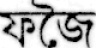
ফজৈ
